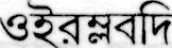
ওইরম্লবদি
